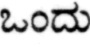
ಒಂದು
